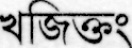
খজিক্তং
